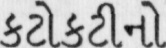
કટોકટીનો
